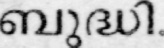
ബുദ്ധി.
